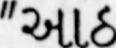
"આઠ
